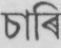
চাৰি
